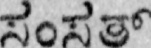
ಸಂಸತ್
